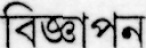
বিজ্ঞাপন
